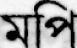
মপি
